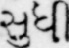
સુધી
